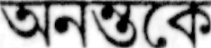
অনন্তকে
